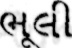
ભૂલી
